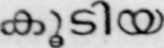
കൂടിയ
